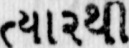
ત્યારથી
